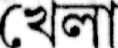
খেলা
